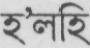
হ'লহি
